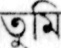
তুমি
